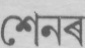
শেনৰ
